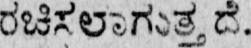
ರಚಿಸಲಾಗುತ್ತದೆ.
